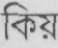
কিয়
